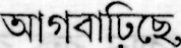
আগবাঢ়িছে,
